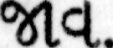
જાવ.
